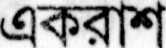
একরাশ
